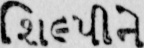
શિલ્પીને
